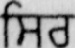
ਸਿਰ
